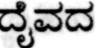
ದೈವದ
